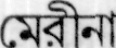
মেরীনা
